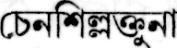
চেনশিল্লক্তুনা
